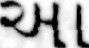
આ
